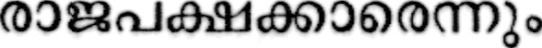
രാജപക്ഷക്കാരെന്നും
